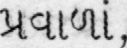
પ્રવાળાં,
